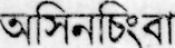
অসিনচিংবা
